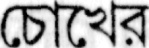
চোখের
